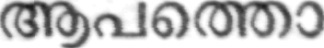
ആപത്തൊ
